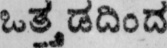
ಒತ್ತಡದಿಂದ
